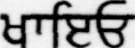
ਖਾਇਓ
